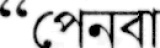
“পেনবা
